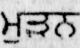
ਮੁੜਨ
